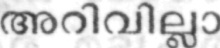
അറിവില്ലാ
